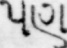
પણ
